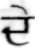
ਦੇ
